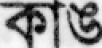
কাঙ
